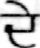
ਦੇ
